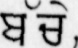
ਬੱਚੇ,
